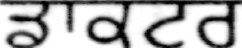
ਡਾਕਟਰ
